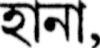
হানা,
